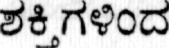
ಶಕ್ತಿಗಳಿಂದ
